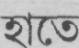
হাতে
